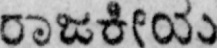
ರಾಜಕೀಯ
